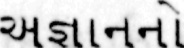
અજ્ઞાનનો
